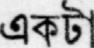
একটা
